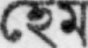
হেম
